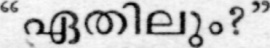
"ഏതിലും?"
